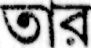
তার
